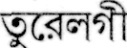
তুরেলগী
